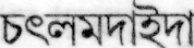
চৎলমদাইদা
